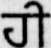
ਹੀ
